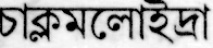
চাক্লমলোইদ্রা
